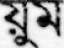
য়ুম
